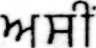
ਅਸੀਂ
